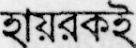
হায়রকই
